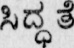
ಸಿದ್ಧತೆ
